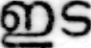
ഇട
